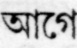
আগে
